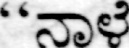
"ನಾಳೆ
